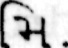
મિ.
